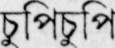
চুপিচুপি
